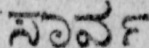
ಸಾರ್ವ
